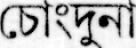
চোংদুনা
